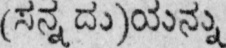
(ಸನ್ನದು)ಯನ್ನು
